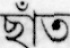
ছাঁত
